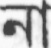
না
